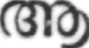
ആ
